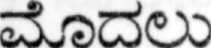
ಮೊದಲು
